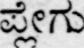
ಪ್ಲೇಗು
